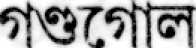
গণ্ডগোল
